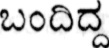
ಬಂದಿದ್ದ
